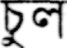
চুল
